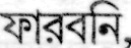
ফারবনি,
